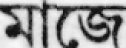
মাজে
